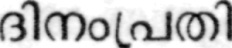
ദിനംപ്രതി
